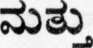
ಮತ್ತು
